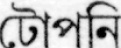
টোপনি
